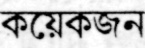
কয়েকজন
